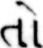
તો
